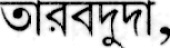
তারবদুদা,
